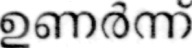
ഉണര്‍ന്ന്
